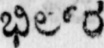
ಭಿಲ್‌ರ
